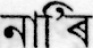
নাৰি
